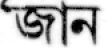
'জান
